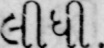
લીધી.
